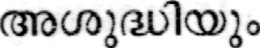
അശുദ്ധിയും
